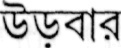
উড়বার
